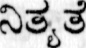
ನಿತ್ಯತೆ
